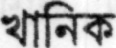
খানিক
